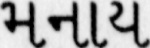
મનાય
